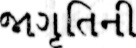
જાગૃતિની
